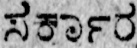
ಸರ್ಕಾರ
